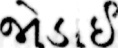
જોડાઈ
